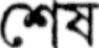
শেষ
